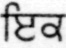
ਇਕ
